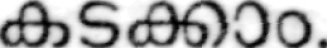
കടക്കാം.
